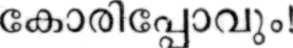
കോരിപ്പോവും!
